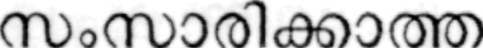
സംസാരിക്കാത്ത
